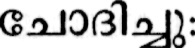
ചോദിച്ചു:
